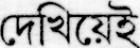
দেখিয়েই
